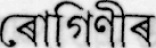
ৰোগিণীৰ
